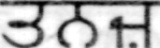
ਤਨਜ਼
